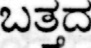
ಬತ್ತದ
